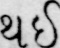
થઈ
